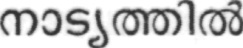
നാട്യത്തില്‍
